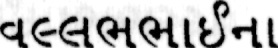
વલ્લભભાઈના
